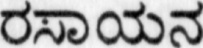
ರಸಾಯನ
